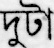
দুটা
